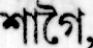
শাগৈ,
